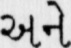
અને
